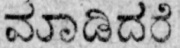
ಮಾಡಿದರೆ
